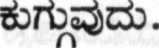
ಕುಗ್ಗುವುದು.
